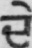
ਦੇ
